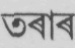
তৰাৰ
